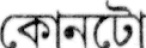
কোনটো
